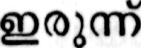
ഇരുന്ന്
